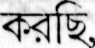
করছি,
